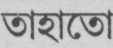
তাহাতো
